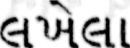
લખેલા
